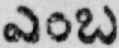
ಎಂಬ
